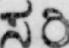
ಸರಿ
